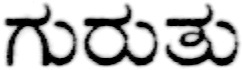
ಗುರುತು
